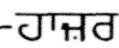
-ਹਾਜ਼ਰ
